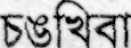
চঙখিবা
